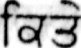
ਕਿਤੇ
